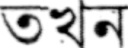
তখন
